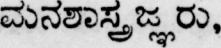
ಮನಶಾಸ್ತ್ರಜ್ಞರು,
